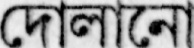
দোলানো
